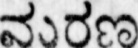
ಮರಣ
